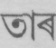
তাৰ
